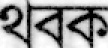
থবক
